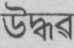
উদ্ধৱ
